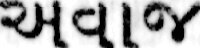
અવાજ
